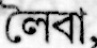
লৈবা,
